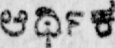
ಆರ್ಥಿಕ
